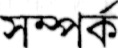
সম্পর্ক
